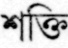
শক্তি
